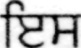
ਇਸ
